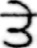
ਤੇ
